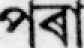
পৰা
